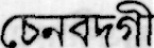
চেনবগী
